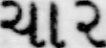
ચાર
